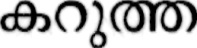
കറുത്ത
